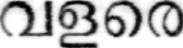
വളരെ
